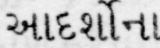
આદર્શોના
